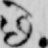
છે.
